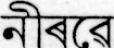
নীৰৱে
